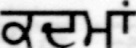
ਕਦਮਾਂ
